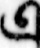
এ
